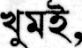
খুমই,
